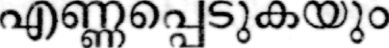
എണ്ണപ്പെടുകയും
